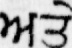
ਅਤੇ
